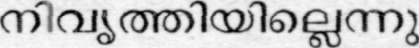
നിവൃത്തിയില്ലെന്നു
